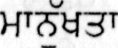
ਮਾਨੁੱਖਤਾ
